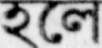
হলে
